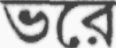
ভরে
